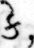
કે,
